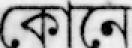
কোনে
